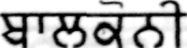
ਬਾਲਕੋਨੀ
